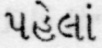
પહેલાં
